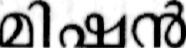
മിഷന്‍
